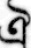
ঐ
